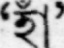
‘হাঁ’
